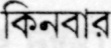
কিনবার
